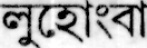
লুহোংবা
